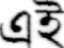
এই
